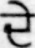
ਦੇ
